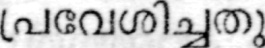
പ്രവേശിച്ചതു
